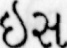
ઇસ
